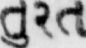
તુરત
